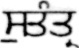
ਸੁਤੰਤ੍ਰ
